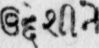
ઉદ્દેશીને
